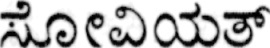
ಸೋವಿಯತ್
